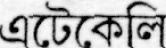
এটেকেলি
